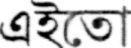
এইতো
